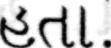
હતા.
